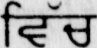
ਵਿੱਚ
